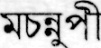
মচন্নুপী
